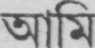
আমি
